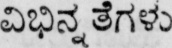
ವಿಭಿನ್ನತೆಗಳು
